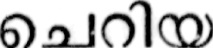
ചെറിയ
